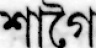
শাগৈ
